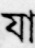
যা
